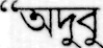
“অদুবু
